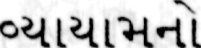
વ્યાયામનો
